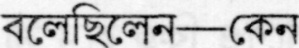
বলেছিলেন–কেন
